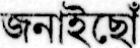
জনাইছোঁ
